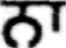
ਨਾ
